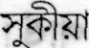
সুকীয়া
